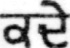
ਕਦੇ
